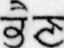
ਭੈਣ
